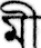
মী
